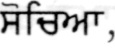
ਸੋਚਿਆ,
